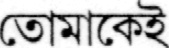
তোমাকেই
